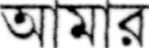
আমার
